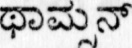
ಥಾಮ್ಸನ್
